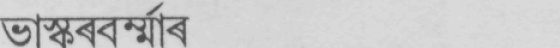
ভাস্কৰবৰ্ম্মাৰ
